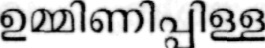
ഉമ്മിണിപ്പിള്ള
